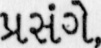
પ્રસંગે,
